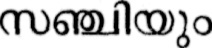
സഞ്ചിയും
